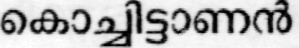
കൊച്ചിട്ടാണന്‍
